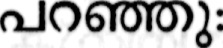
പറഞ്ഞു:
